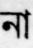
না
